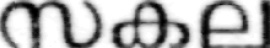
സകല
